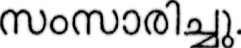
സംസാരിച്ചു.
